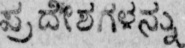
ಪ್ರದೇಶಗಳನ್ನು
